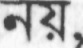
নয়,
